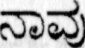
ನಾವು
